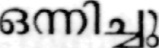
ഒന്നിച്ചു
